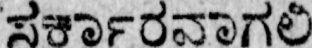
ಸರ್ಕಾರವಾಗಲಿ
